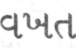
વખત
